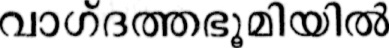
വാഗ്ദത്തഭൂമിയില്‍
